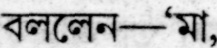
বললেন–‘মা,
